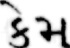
કેમ
